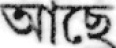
আছে
